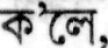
ক'লে,
